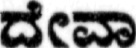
ದೇವಾ
